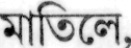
মাতিলে,
